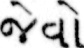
જેવો
